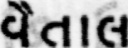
વેતાલ
